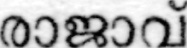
രാജാവ്
